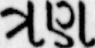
ત્રણ
